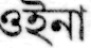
ওইনা
